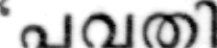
‘പവതി
